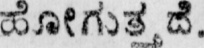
ಹೋಗುತ್ತದೆ.
